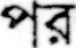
পর
